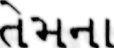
તેમના
